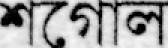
শগোল
